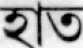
হাত
